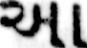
આ
